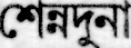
শেন্নদুনা
